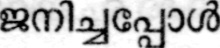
ജനിച്ചപ്പോള്‍
